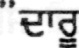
''ਦਾਰੂ
